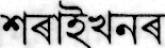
শৰাইখনৰ
